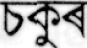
চকুৰ
